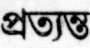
প্রত্যন্ত
